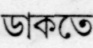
ডাকতে
